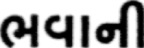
ભવાની
